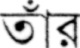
তাঁর
